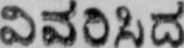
ವಿವರಿಸಿದ
